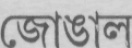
জোঙাল
